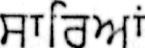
ਸਾਰਿਆਂ
